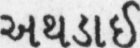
અથડાઈ
